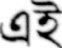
এই
